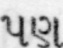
પણ
